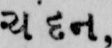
ચંદન,
